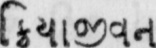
ક્રિયાજીવન
